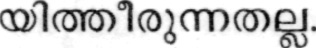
യിത്തീരുന്നതല്ല.
